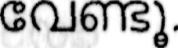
വേണ്ടൂ.
